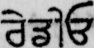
ਰੇਡੀਓ
